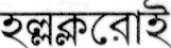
হল্লক্লরোই
